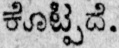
ಕೊಟ್ಟಿದೆ.
